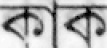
কাক
